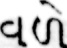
વળે
